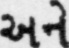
અને
